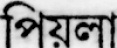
পিয়লা
